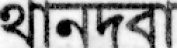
থানদবা
